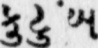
કુટુંબ
